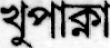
খুপাক্না
